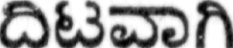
ದಿಟವಾಗಿ
